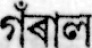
গঁৰাল
